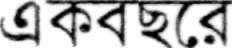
একবছরে
